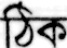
ঠিক
